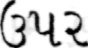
ઉપર
